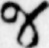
જ
